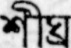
শীঘ্র
